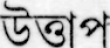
উত্তাপ
